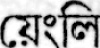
য়েংলি
